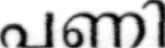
പണി
